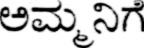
ಅಮ್ಮನಿಗೆ
